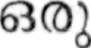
ഒരു
